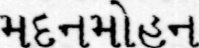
મદનમોહન
